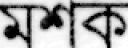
মশক
